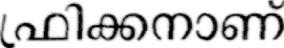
ഫ്രിക്കനാണ്
